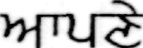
ਆਪਣੇ
